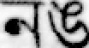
নঙ
